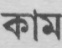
কাম
